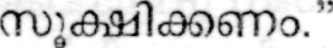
സൂക്ഷിക്കണം.”
